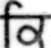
ਕਿ
